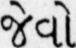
જેવો
